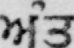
ਅੰਤ
